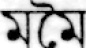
মমৈ
